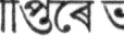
বাপ্তিৰে
